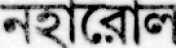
নহারোল
